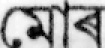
মোৰ
